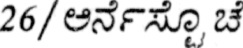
26/ಆರ್ನೆಸ್ಟೊಚೆ
